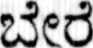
ಬೇರೆ
